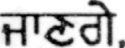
ਜਾਣਗੇ,
